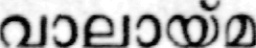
വാലായ്മ
